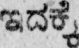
ಇದಕ್ಕೆ
